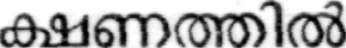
ക്ഷണത്തില്‍
